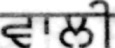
ਵਾਲੀ
